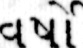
વર્ષો
